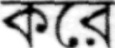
করে
